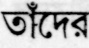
তাঁদের
